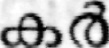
കര്‍
